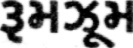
રૂમઝૂમ
